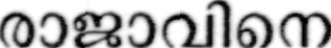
രാജാവിനെ
